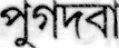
পুগদবা
